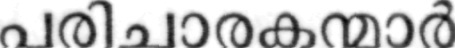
പരിചാരകന്മാര്‍
